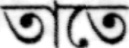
তাতে
